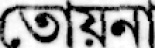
তোয়না
